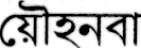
য়ৌহনবা
